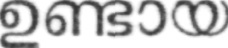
ഉണ്ടായ
